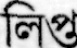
লিপ্ত
